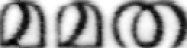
മമത
